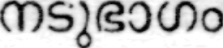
നടുഭാഗം
